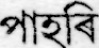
পাহৰি
